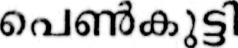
പെണ്‍കുട്ടി
